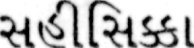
સહીસિક્કા
